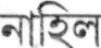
নাহিল
